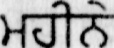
ਮਹੀਨੇ
